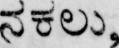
ನಕಲು,
